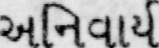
અનિવાર્ય
